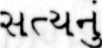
સત્યનું
